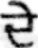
ਦੇ
